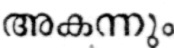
അകന്നൂം
